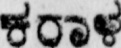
ಕರಾಳ
